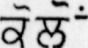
ਕੋਲੋਂ
